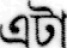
এটা
